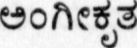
ಅಂಗೀಕೃತ
